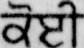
ਕੋਈ
